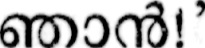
ഞാന്‍!’
